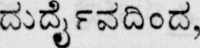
ದುರ್ದೈವದಿಂದ,
